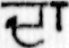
ਦਾ
